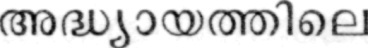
അദ്ധ്യായത്തിലെ
